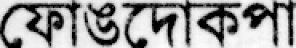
ফোঙদোকপা
